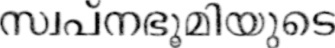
സ്വപ്നഭൂമിയുടെ
